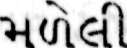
મળેલી
